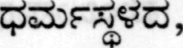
ಧರ್ಮಸ್ಥಳದ,
